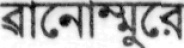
ৱানোম্মুরে
